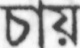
চায়
